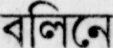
বলিনে
